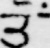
ਤੋਂ
